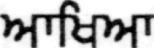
ਆਖਿਆ
